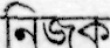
নিজক
